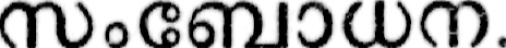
സംബോധന.
